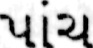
પાંચ
